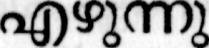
എഴുന്നു
